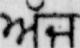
ਅੱਜ
